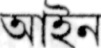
আইন
